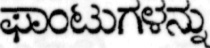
ಫಾಂಟುಗಳನ್ನು
